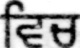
ਵਿਚ
